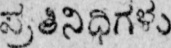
ಪ್ರತಿನಿಧಿಗಳು
